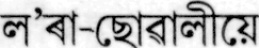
ল'ৰা-ছোৱালীয়ে
